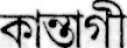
কান্তাগী
